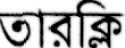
তারক্লি
